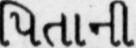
પિતાની
